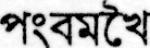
পংবমখৈ
